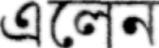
এলেন
